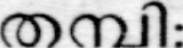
തമ്പി:
